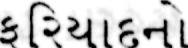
ફરિયાદનો
